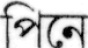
পিনে
